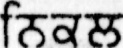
ਨਿਕਲ
